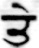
ਤੇ
